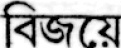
বিজয়ে
